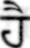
ਹੈ
